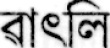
ৱাৎলি
